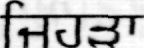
ਜਿਹੜਾ
